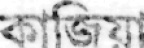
কাজিয়া
